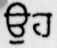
ਉਹ
